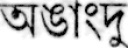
অঙাংদু
